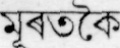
মূৰতকৈ
